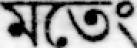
মতেং
